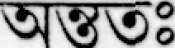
অন্ততঃ
